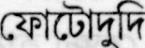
ফোটোদুদি
